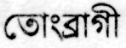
তোংব্রাগী
